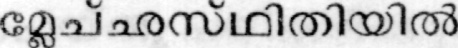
മ്ലേച്ഛസ്ഥിതിയില്‍
